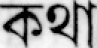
কথা
